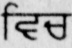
ਵਿਚ
